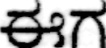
ಈಗ
